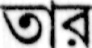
তার
